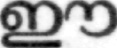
ഈ
